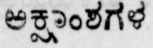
ಅಕ್ಷಾಂಶಗಳ
